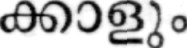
ക്കാളും
